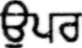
ਉਪਰ
